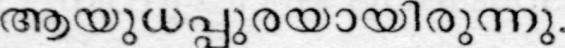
ആയുധപ്പുരയായിരുന്നു.
